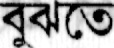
বুঝতে
